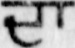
ਦਾ
